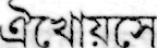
ঐখোয়সে
